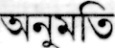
অনুমতি
